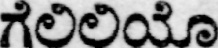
ಗೆಲಿಲಿಯೊ
